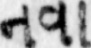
નવા
